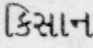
કિસાન
